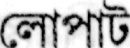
লোপাট
